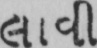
લાવી
